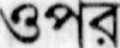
ওপর
